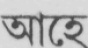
আহে
